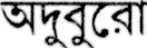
অদুবুরো
